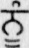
ਨੂੰ
